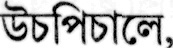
উচপিচালে,
